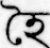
হৈ
